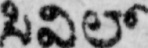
ಸಿವಿಲ್
